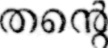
തന്റെ
